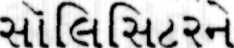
સૉલિસિટરને
